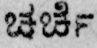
ಚರ್ಚೆ
